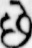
છે
